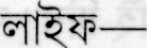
লাইফ-
